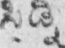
ಸಿಡ್ನಿ
